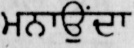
ਮਨਾਉਂਦਾ
